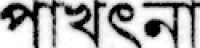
পাখৎনা
